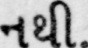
નથી.
